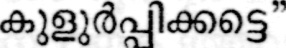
കുളുര്‍പ്പിക്കട്ടെ”
